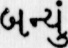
બન્યું
